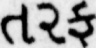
તરફ
